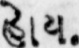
હોય.
